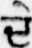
ਦੇ
